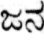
ಜನ
